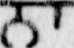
ਨਾ
